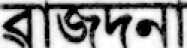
ৱাজদনা
